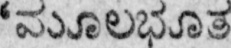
‘ಮೂಲಭೂತ
